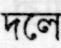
দলে
